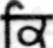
ਕਿ
